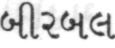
બીરબલ
